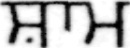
ਸ਼ਾਮ
